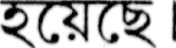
হয়েছে।
